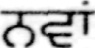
ਨਵਾਂ
